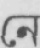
নে
